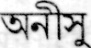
অনীসু
